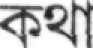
কথা
